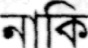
নাকি
